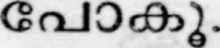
പോകൂ.
